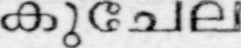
കുചേല
